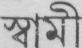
স্বামী
